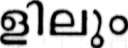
ളിലും
